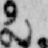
ಪಿ.
